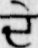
ਦੇ
